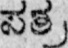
ಪತ್ರ
